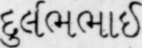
દુર્લભભાઈ
